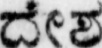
ದೇಶ
